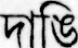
দাঙি
